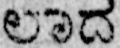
ಲಾದ
